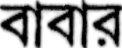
বাবার
